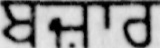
ਬਜ਼ਾਰ
